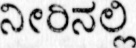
ನೀರಿನಲ್ಲಿ
